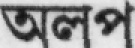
অলপ
